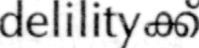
delilityക്ക്
